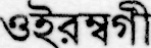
ওইরম্বগী
